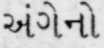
અંગેનો
